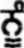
ਨੂੰ
